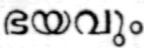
ഭയവും
